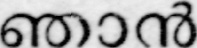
ഞാന്‍
